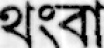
থংবা
